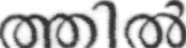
ത്തില്‍
